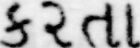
કરતા
